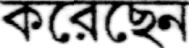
করেছেন
